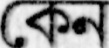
কেন
